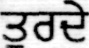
ਤੁਰਦੇ
